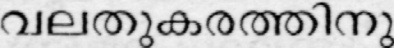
വലതുകരത്തിനു
